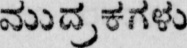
ಮುದ್ರಕಗಳು
